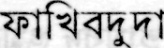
ফাখিবদুদা
